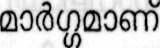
മാര്‍ഗ്ഗമാണ്
